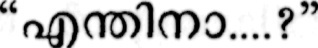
“എന്തിനാ....?”
